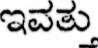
ಇವತ್ತು
